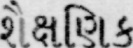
શૈક્ષણિક
